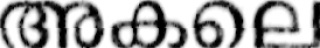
അകലെ
